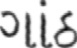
ગાંઠ
